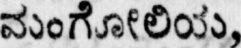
ಮಂಗೋಲಿಯ,
